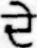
ਦੇ
